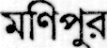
মণিপুর
